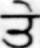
ਤੇ
